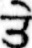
ਤੇ
